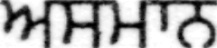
ਅਸਮਾਨ
